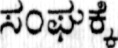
ಸಂಘಕ್ಕೆ
